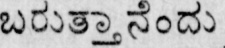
ಬರುತ್ತಾನೆಂದು
